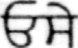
ਓਸੇ
